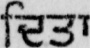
ਦਿਤਾ
